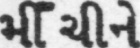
મીંચીને
